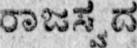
ರಾಜಸ್ವದ
